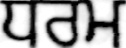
ਧਰਮ
